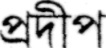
প্রদীপ
